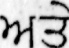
ਅਤੇ
